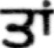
ਤਾਂ
